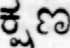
ಕ್ಷಣ
